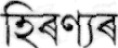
হিৰণ্যৰ
